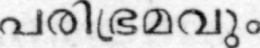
പരിഭ്രമവും
